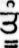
ਤੂੰ
